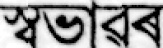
স্বভাৱৰ
